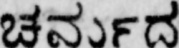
ಚರ್ಮದ
